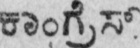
ಕಾಂಗ್ರೆಸ್
